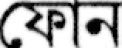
ফোন
